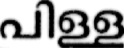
പിള്ള
